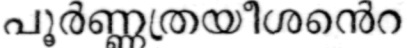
പൂര്‍ണ്ണത്രയീശന്റെ
